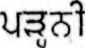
ਪੜ੍ਹਨੀ
